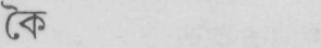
কৈ
